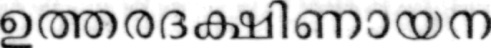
ഉത്തരദക്ഷിണായന
